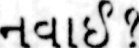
નવાઈ?
